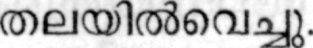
തലയില്‍വെച്ചു.
